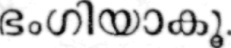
ഭംഗിയാകൂ.
